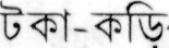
টকা-কড়ি
